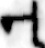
ન
